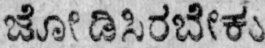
ಜೋಡಿಸಿರಬೇಕು
